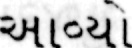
આવ્યો
